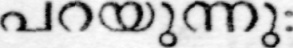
പറയുന്നു:
